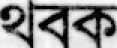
থবক
